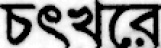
চৎখরে
